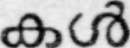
കള്‍
